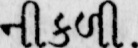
નીકળી.
